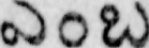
ಎಂಬ
